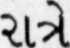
રાત્રે
